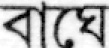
বাঘে
